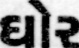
ઘોર
